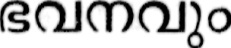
ഭവനവും
